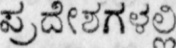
ಪ್ರದೇಶಗಳಲ್ಲಿ
